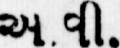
આવી.
